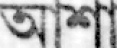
আশা
